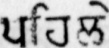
ਪਹਿਲੇ
